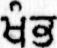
ਖੰਭ
